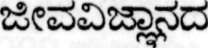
ಜೀವವಿಜ್ಞಾನದ
